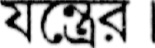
যন্ত্রের।
